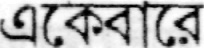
একেবারে
